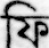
ফি
